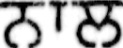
ਨਾਲ
